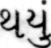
થયું
